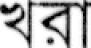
খরা
